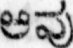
ಅವು
